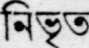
নিভৃত
